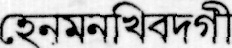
হেনমনখিবদগী
